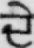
ਦੇ
